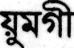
য়ুমগী
